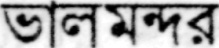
ভালমন্দর
